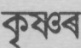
কৃষ্ণৰ
